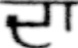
ਦਾ
